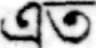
এত
